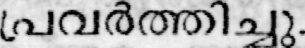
പ്രവര്‍ത്തിച്ചു.
